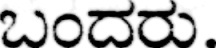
ಬಂದರು.
